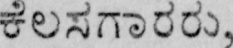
ಕೆಲಸಗಾರರು,
